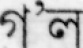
গ'ল
